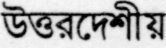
উত্তরদেশীয়
